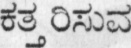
ಕತ್ತರಿಸುವ
